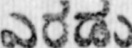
ಎರಡು
